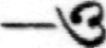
-ও
